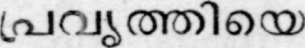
പ്രവൃത്തിയെ
